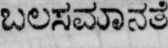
ಬಲಸಮಾನತೆ
